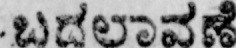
ಬದಲಾವಣೆ
